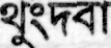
থুংদবা
